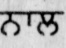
ਨਾਲ
